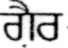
ਗ਼ੈਰ
